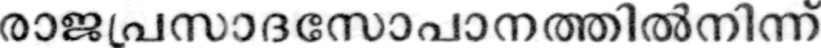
രാജപ്രസാദസോപാനത്തില്‍നിന്ന്
